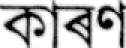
কাৰণ
